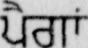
ਪੈਗਾਂ
